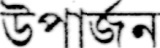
উপার্জন
